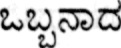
ಒಬ್ಬನಾದ
